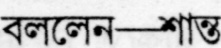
বললেন–শান্ত
